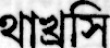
থাখ্রসি
